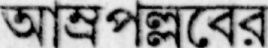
আম্রপল্লবের
